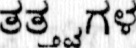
ತತ್ತ್ವಗಳ
